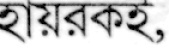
হায়রকই,
